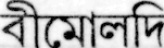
বীমোলদি
